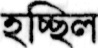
হচ্ছিল
